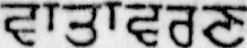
ਵਾਤਾਵਰਣ
